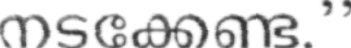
നടക്കേണ്ട."
